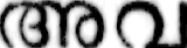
അവ
